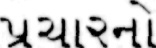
પ્રચારનો
